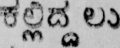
ಕಲ್ಲಿದ್ದಲು
